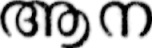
ആന
